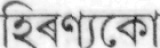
হিৰণ্যকো
